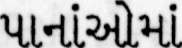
પાનાંઓમાં
